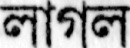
লাগল
